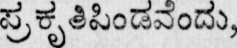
ಪ್ರಕೃತಿಪಿಂಡವೆಂದು,
